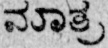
ಮಾತ್ರ
